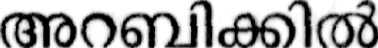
അറബിക്കില്‍
